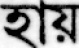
হায়
